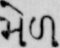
મેળ
